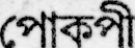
পোকপী
